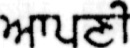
ਆਪਣੀ
